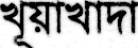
খূয়াখাদা
